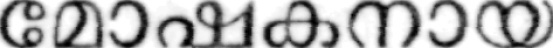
മോഷകനായ
